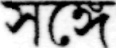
সঙ্গে
